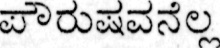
ಪೌರುಷವನೆಲ್ಲ
